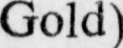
Gold)
